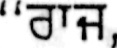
''ਰਾਜ,
